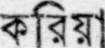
করিয়া
